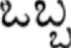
ಒಬ್ಬ
